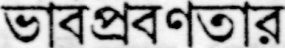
ভাবপ্রবণতার
